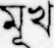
মূখ
